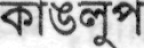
কাঙলুপ
